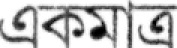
একমাত্র
